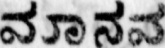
ಮಾನವ
